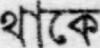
থাকে
